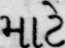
માટે
